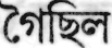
গৈছিল
